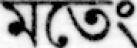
মতেং
